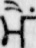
ਮੈਂ
